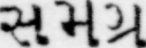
સમગ્ર
